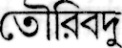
তৌরিবদু
